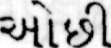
ઓછી
